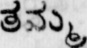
ತಮ್ಮ
